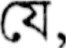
যে,
